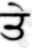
ਤੇ
